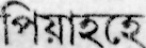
পিয়াহহে
